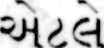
એટલે
